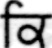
ਕਿ
